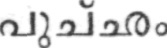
പുച്ഛം
